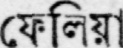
ফেলিয়া
